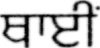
ਥਾਈਂ
